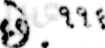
છે.૧૧૬
